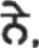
ਨੇ,
